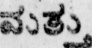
ಮತ್ತು
